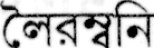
লৈরম্বনি
